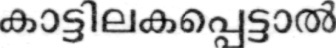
കാട്ടിലകപ്പെട്ടാല്‍
